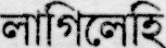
লাগিলেহি
